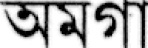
অমগা
